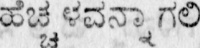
ಹೆಚ್ಚಳವನ್ನಾಗಲಿ
